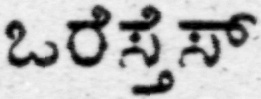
ಒರೆಸ್ತೆಸ್
